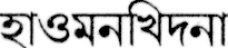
হাওমনখিদনা
